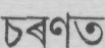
চৰণত
